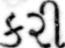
કરી
